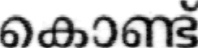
കൊണ്ട്
